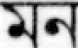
মন
